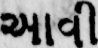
આવી
